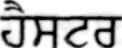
ਹੈਸਟਰ
